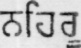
ਨਹਿਰੂ
